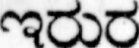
ಇರುರ
